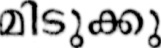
മിടുക്കു
